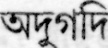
অদুগদি
